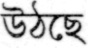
উঠছে
